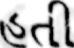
હતી
